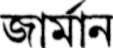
জার্মান
